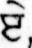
ਏ,
